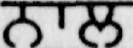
ਨਾਲ
